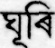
ঘূৰি
